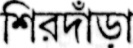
শিরদাঁড়া
